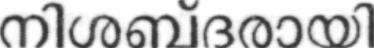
നിശബ്ദരായി
